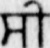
ਸੀ
